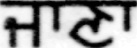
ਜਾਣਾ
